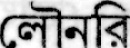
লৌনরি
